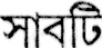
সাবটি
